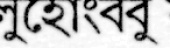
লুহোংববু
